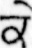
ਕੇ
